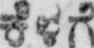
ಕೆಳಗೆ
